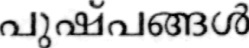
പുഷ്പങ്ങള്‍
